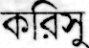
করিসু
